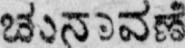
ಚುನಾವಣೆ
